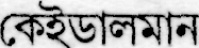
কেইডালমান
